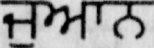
ਜੁਆਨ
